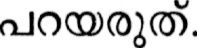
പറയരുത്.
